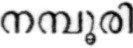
നമ്പൂരി
